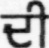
ਦੀ
